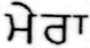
ਮੇਰਾ
